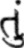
તું
